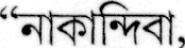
"নাকান্দিবা,
